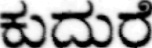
ಕುದುರೆ
